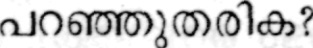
പറഞ്ഞുതരിക?
